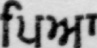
ਪਿਆ
